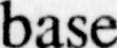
base
